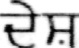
ਦੇਸ਼
